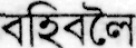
বহিবলৈ
